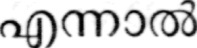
എന്നാല്‍
